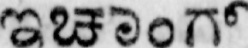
ಇಚಾಂಗ್
